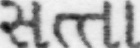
સત્તા
